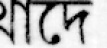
থাদে
